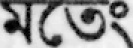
মতেং
